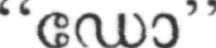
"ഡോ"
